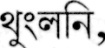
থুংলনি,
